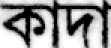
কাদা
